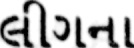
લીગના
